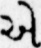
એ
